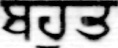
ਬਹੁਤ
